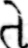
તે
